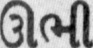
ઊભી
